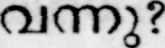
വന്നു?
